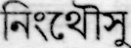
নিংথৌসু
